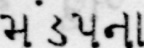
મંડપના
